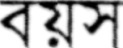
বয়স
